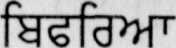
ਬਿਫਰਿਆ
